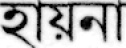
হায়না
